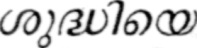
ശുദ്ധിയെ
